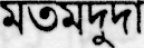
মতমদুদা
